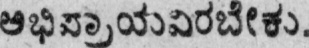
ಅಭಿಪ್ರಾಯವಿರಬೇಕು.
